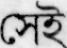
সেই
